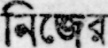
নিজের
